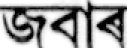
জবাৰ
